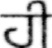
ਹੀ
